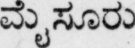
ಮೈಸೂರು
